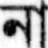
না
